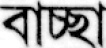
বাচ্ছা
